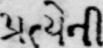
પ્રત્યેની
